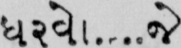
ધરવો....જે
